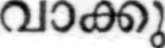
വാക്കു
